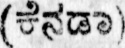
(ಕೆನಡಾ)
